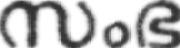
സംഭ
